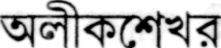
অলীকশেখর
